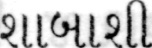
શાબાશી
